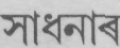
সাধনাৰ
